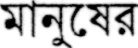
মানুষের
